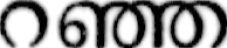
റഞ്ഞ
